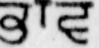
ਭਾਵ
